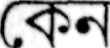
কেন
